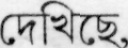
দেখিছে,
